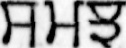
ਸਮਝ
